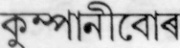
কুম্পানীবোৰ
